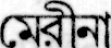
মেরীনা
